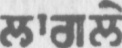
ਲਾਗਲੇ
